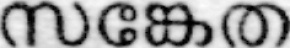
സങ്കേത
